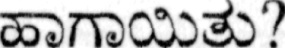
ಹಾಗಾಯಿತು?
